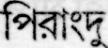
পিরাংদু
